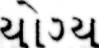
યોગ્ય
